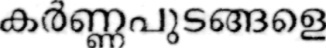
കര്‍ണ്ണപുടങ്ങളെ
